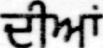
ਦੀਆਂ
